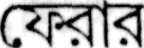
ফেরার
